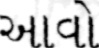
આવો
